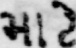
માટે
